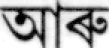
আৰু
